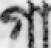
গা
